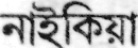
নাইকিয়া
